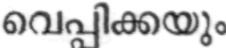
വെപ്പിക്കയും
